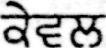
ਕੇਵਲ
